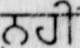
ਨਹੀਂ
